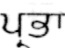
ਪ੍ਰਭਾ
